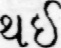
થઈ
